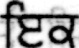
ਇਕ
